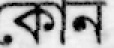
কোন
